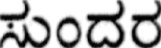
ಸುಂದರ
